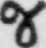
જ
